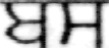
ਬਸ
